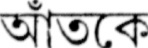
আঁতকে
